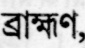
ব্রাহ্মণ,
